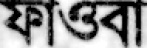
ফাওবা
